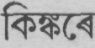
কিঙ্কৰে
